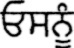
ਓਸਨੂੰ
